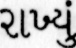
રાખ્યું
